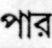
পার
